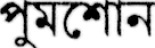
পুমশোন
